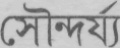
সৌন্দৰ্য্য
